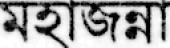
মহাজন্না
